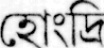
হোংদ্রি
